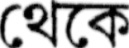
থেকে
